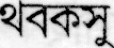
থবকসু
